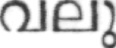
വലു
